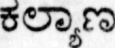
ಕಲ್ಯಾಣ
